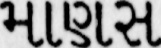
માણસ
